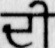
ਦੀ
